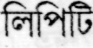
লিপিটি
